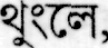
থুংলে,
